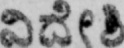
ವಿದೇಶಿ
